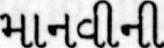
માનવીની
